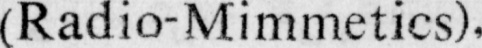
(Radio-Mimmetics).
